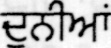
ਦੁਨੀਆਂ
